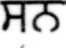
ਸਨ
